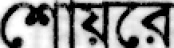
শোয়রে
